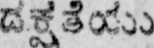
ದಕ್ಷತೆಯು
